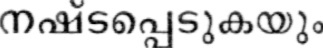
നഷ്ടപ്പെടുകയും
